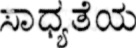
ಸಾಧ್ಯತೆಯ
